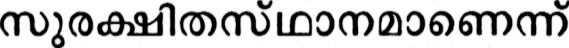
സുരക്ഷിതസ്ഥാനമാണെന്ന്
